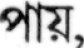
পায়,
